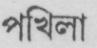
পখিলা
